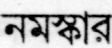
নমস্কার
